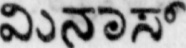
ಮಿನಾಸ್
